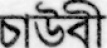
চাউবী
